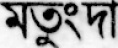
মতুংদা
